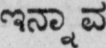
ಇನ್ನಾವ
